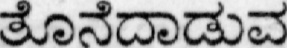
ತೊನೆದಾಡುವ
